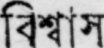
বিশ্বাস
